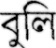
বুলি
